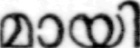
മായി
